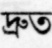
দ্রুত
